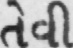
તેવી
